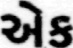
એક
